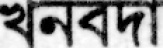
খনবদা
